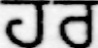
ਹਰ
